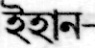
ইহান-
